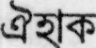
ঐহাক
